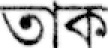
তাক
